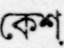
কেশ
